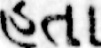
હતા
